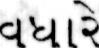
વધારે
